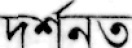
দর্শনত
